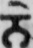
ਨੇ
